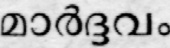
മാര്‍ദ്ദവം
